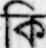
কি
